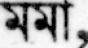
মমা,
